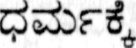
ಧರ್ಮಕ್ಕೆ
